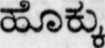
ಹೊಕ್ಕು
